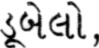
ડૂબેલો,
